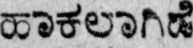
ಹಾಕಲಾಗಿದೆ
